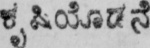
ಕೃಷಿಯೊಡನೆ
